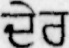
ਦੇਰ
